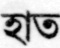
হাত
